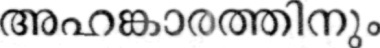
അഹങ്കാരത്തിനും
